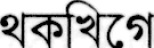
থকখিগে
